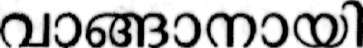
വാങ്ങാനായി
